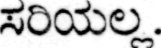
ಸರಿಯಲ್ಲ.
